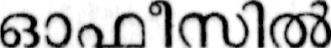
ഓഫീസില്‍
